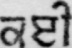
ਕਈ
